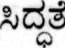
ಸಿದ್ಧತೆ
